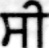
ਸੀ
